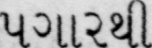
પગારથી
